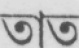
তাত
